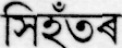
সিহঁতৰ
